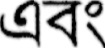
এবং
